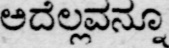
ಅದೆಲ್ಲವನ್ನೂ
